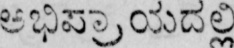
ಅಭಿಪ್ರಾಯದಲ್ಲಿ
